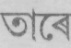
তাৰে
